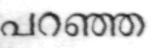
പറഞ്ഞ
